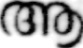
ആ
